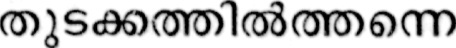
തുടക്കത്തില്‍ത്തന്നെ
